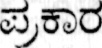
ಪ್ರಕಾರ
